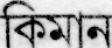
কিমান
